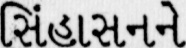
સિંહાસનને
